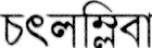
চৎলম্লিবা
